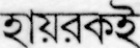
হায়রকই
